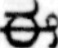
ಈ
